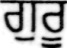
ਗੁਰੂ
